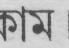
কাম
